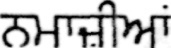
ਨਮਾਜ਼ੀਆਂ
